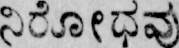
ನಿರೋಧವು
